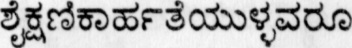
ಶೈಕ್ಷಣಿಕಾರ್ಹತೆಯುಳ್ಳವರೂ
